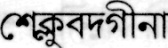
শেক্লুবদগীনা
